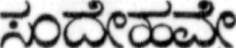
ಸಂದೇಹವೇ
